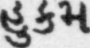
હુકમ
